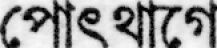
পোৎথাগে
